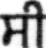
ਸੀ
